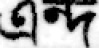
অন্দ
